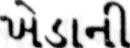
ખેડાની
